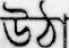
উঠা
